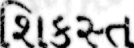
શિકસ્ત
